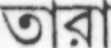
তারা
